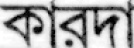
কারদা
